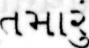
તમારું
